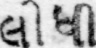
લીધી
